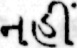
નહીં
